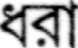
ধরা
